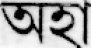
অহা
